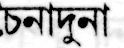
চৈনাদুনা
